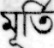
মূর্তি
